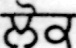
ਲੋਕ
